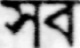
সব
